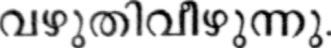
വഴുതിവീഴുന്നു.
